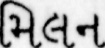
મિલન
